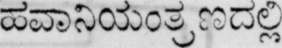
ಹವಾನಿಯಂತ್ರಣದಲ್ಲಿ
